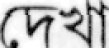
দেখা
